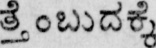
ತ್ತೆಂಬುದಕ್ಕೆ
